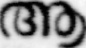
ആ
